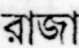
রাজা
